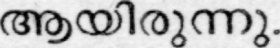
ആയിരുന്നു.
